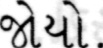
જોયો.
